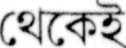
থেকেই
